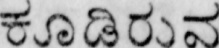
ಕೂಡಿರುವ
